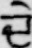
ਦੇ
